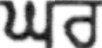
ਘਰ
